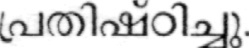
പ്രതിഷ്ഠിച്ചു.
